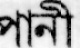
পানী
